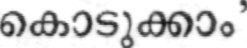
കൊടുക്കാം’
